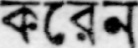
করেন
